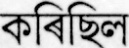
কৰিছিল
